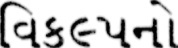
વિકલ્પનો
